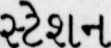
સ્ટેશન
